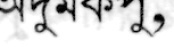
অদুমকপু,
